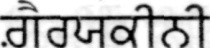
ਗ਼ੈਰਯਕੀਨੀ
